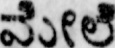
ಮೇಲೆ
